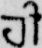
ਹੀ
